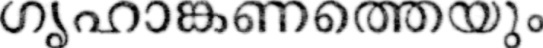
ഗൃഹാങ്കണത്തെയും
